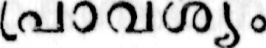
പ്രാവശ്യം
